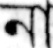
না
